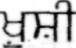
ਖ਼ੁਸ਼ੀ
